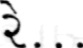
રે...
